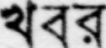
খবর
